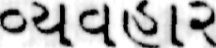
વ્યવહાર
